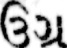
ઉગ્ર
